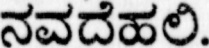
ನವದೆಹಲಿ.
